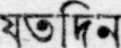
যতদিন
